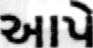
આપે
